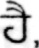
ਹੈ,
